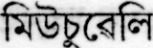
মিউচুৱেলি
